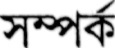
সম্পর্ক
